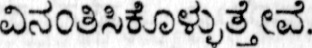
ವಿನಂತಿಸಿಕೊಳ್ಳುತ್ತೇವೆ.
